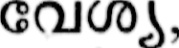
വേശ്യ,
